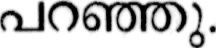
പറഞ്ഞു.
